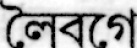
লৈবগে
